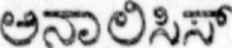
ಅನಾಲಿಸಿಸ್
